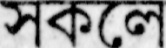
সকলে
